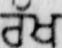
ਰੱਖ
